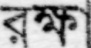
রক্ষা
